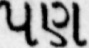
પણ
